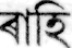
ৰাহি
